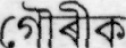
গৌৰীক
